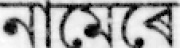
নামেৰে
